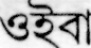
ওইবা
